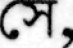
সে,
